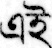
এই
